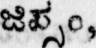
ಜಿಪ್ಸಂ,
